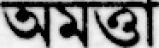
অমত্তা
